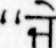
''ਜੇ
